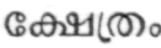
ക്ഷേത്രം
